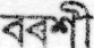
বৰশী
